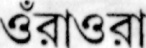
ওঁরাওরা
